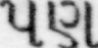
પણ
